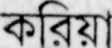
করিয়া
